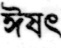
ঈষত্
